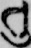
તુ
